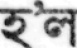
হ'ল
